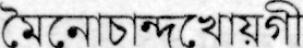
মৈনোচান্দখোয়গী
